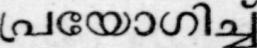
പ്രയോഗിച്ച്
